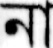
না
